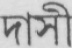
দাসী
